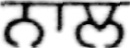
ਨਾਲ
